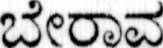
ಬೇರಾವ
